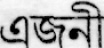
এজনী
